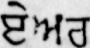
ਏਅਰ
